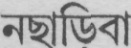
নছাড়িবা
